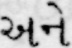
અને
